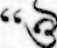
“ঔ
